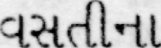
વસતીના
